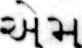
એમ
